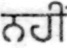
ਨਹੀਂ
